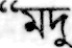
“মদু
